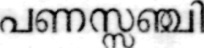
പണസ്സഞ്ചി
